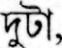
দুটা,
